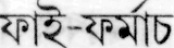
ফাই-ফর্মাচ
